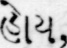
હોય,
